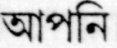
‘আপনি
